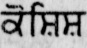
ਕੋਸ਼ਿਸ਼
